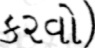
કરવો)
